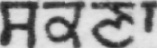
ਸਕਣਾ
